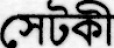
সেটকী
